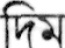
দিম
